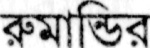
রুমান্ডির
